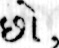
છો,
